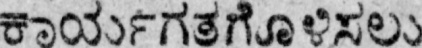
ಕಾರ್ಯಗತಗೊಳಿಸಲು
